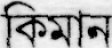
কিমান
